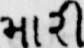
મારી
